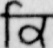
ਕਿ
